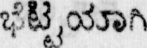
ಭೆಟ್ಟಿಯಾಗಿ
